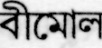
বীমোল
